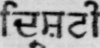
ਦ੍ਰਿਸ਼ਟੀ
